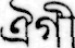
ঐগী
